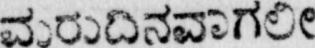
ಮರುದಿನವಾಗಲೀ
